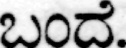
ಬಂದೆ.
